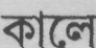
কালে
